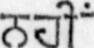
ਨਹੀਂ
